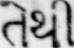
તેથી
